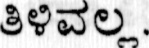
ತಿಳಿವಲ್ಲ.
